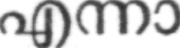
എന്നാ
